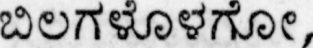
ಬಿಲಗಳೊಳಗೋ,
